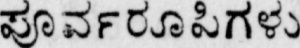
ಪೂರ್ವರೂಪಿಗಳು
